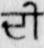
ਦੀ
